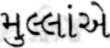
મુલ્લાંએ
